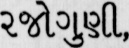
રજોગુણી,
